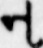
ન
